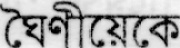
ঘৈণীয়েকে
